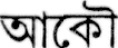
আকৌ
